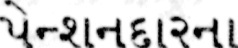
પેન્શનદારના
